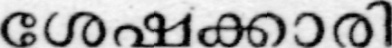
ശേഷക്കാരി
